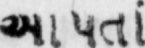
આપતાં
